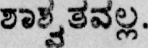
ಶಾಶ್ವತವಲ್ಲ.
